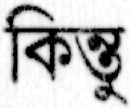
কিন্তু
